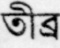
তীব্র
